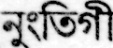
নুংতিগী
